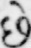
છે
